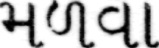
મળવા
